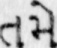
તમે
